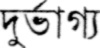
দুর্ভাগ্য
